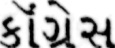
કૉંગ્રેસ
